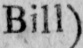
Bill)
